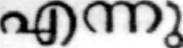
എന്നു
